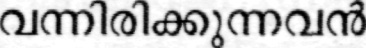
വന്നിരിക്കുന്നവന്‍
